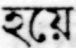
হয়ে
